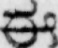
ಈ
